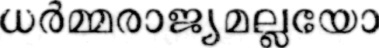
ധര്‍മ്മരാജ്യമല്ലയോ
